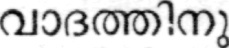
വാദത്തിനു
